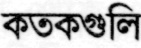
কতকগুলি
